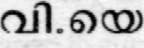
വി.യെ
